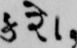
કરો,
